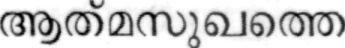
ആത്മസുഖത്തെ
